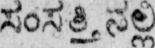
ಸಂಸತ್ತಿನಲ್ಲಿ
